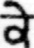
ਕੇ
